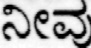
ನೀವು
